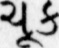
ચૂક
